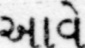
આવે
